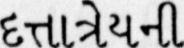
દત્તાત્રેયની
